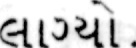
લાગ્યો.
